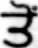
ਤੋਂ
